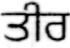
ਤੀਰ
